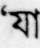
‘যা
